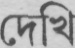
দেখি
